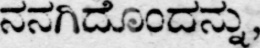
ನನಗಿದೊಂದನ್ನು,
